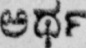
ಅರ್ಥ
